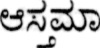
ಆಸ್ತಮಾ
